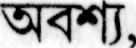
অবশ্য,
